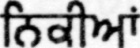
ਨਿਕੀਆਂ
